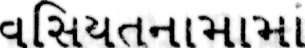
વસિયતનામામાં
